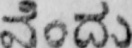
ವೆಂದು
